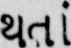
થતાં
